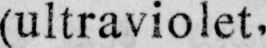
(ultraviolet,
